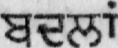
ਬਦਲਾਂ
